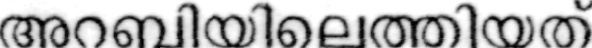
അറബിയിലെത്തിയത്
